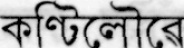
কণ্টিলৌৱে
